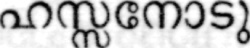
ഹസ്സനോടു
